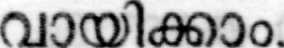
വായിക്കാം.
